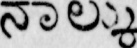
ನಾಲ್ಕು
